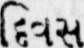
દિવસ
